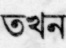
তখন
